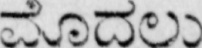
ಮೊದಲು
